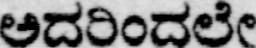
ಅದರಿಂದಲೇ
